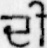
ਦੀ
